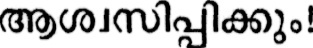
ആശ്വസിപ്പിക്കും!
